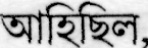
আহিছিল,
